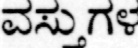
ವಸ್ತುಗಳ
